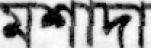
মশাদা
